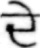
ਦੇ
